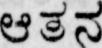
ಆತನ
